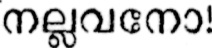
നല്ലവനോ!
